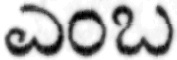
ಎಂಬ
